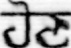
ਹੋਣ
